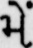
મેં
